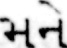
મને
